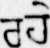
ਰਹੇ
